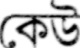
কেউ
